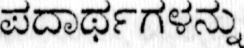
ಪದಾರ್ಥಗಳನ್ನು
